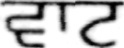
ਵਾਟ
